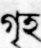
গৃহ
